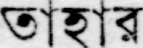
তাহার
